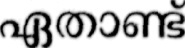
ഏതാണ്ട്
